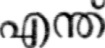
എന്ത്
